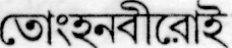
তোংহনবীরোই
